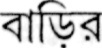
বাড়ির
